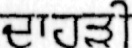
ਦਾਹੜੀ
